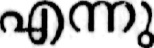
എന്നു
